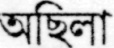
অছিলা
